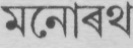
মনোৰথ
